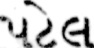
પટેલ
